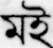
মই
